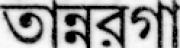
তান্নরগা
